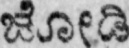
ಜೋಡಿ
